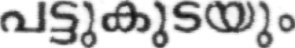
പട്ടുകുടയും
